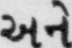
અને
